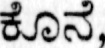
ಕೊನೆ,
